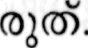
രുത്.
